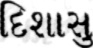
દિશાસુ
